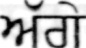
ਅੱਗੇ
